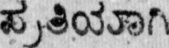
ಪ್ರತಿಯಾಗಿ
